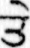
ਤੇ
